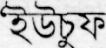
'ইউচুফ
